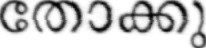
തോക്കു
